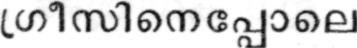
ഗ്രീസിനെപ്പോലെ
